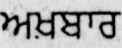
ਅਖ਼ਬਾਰ
